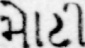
મોટી
